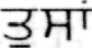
ਤੁਸਾਂ
